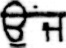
ਉਂਜ
